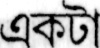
একটা
